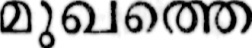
മുഖത്തെ
